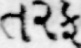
તરક
